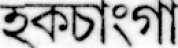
হকচাংগা
